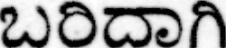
ಬರಿದಾಗಿ
